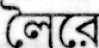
লৈরে
